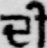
ਦੀ
